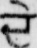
ਦੇ
